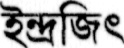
ইন্দ্রজিৎ
